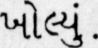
ખોલ્યું.
